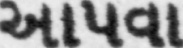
આપવા
